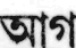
আগ
